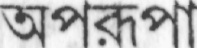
অপরূপা
